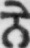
ਨੇ
